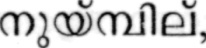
നുയ്മ്പില്,
